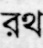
রথ
